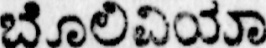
ಬೊಲಿವಿಯಾ
